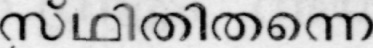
സ്ഥിതിതന്നെ
